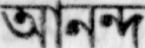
আনন্দ
